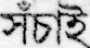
সঁচাই
